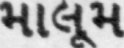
માલૂમ
